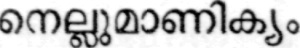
നെല്ലുമാണിക്യം
